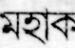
মহাক
